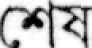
শেষ
